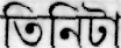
তিনিটা
